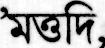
’মত্তদি,
